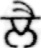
ਲੈ
